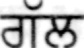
ਗੱਲ
